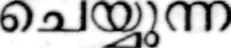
ചെയ്യുന്ന
